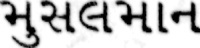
મુસલમાન
